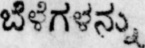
ಬೆಳೆಗಳನ್ನು
